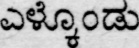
ಎಳ್ಕೊಂಡು
